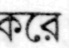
করে
